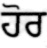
ਹੋਰ
